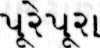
પૂરેપૂરા
